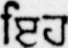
ਇਹ
